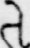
તે
